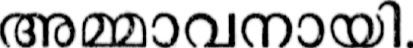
അമ്മാവനായി.
